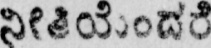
ನೀತಿಯೆಂದರೆ
